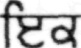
ਇਕ
